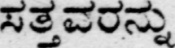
ಸತ್ತವರನ್ನು
